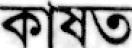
কাষত
